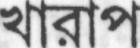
খারাপ
